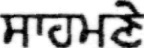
ਸਾਹਮਣੇ
